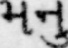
મનુ
